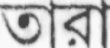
তারা
